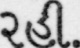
રહી.
